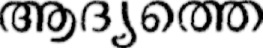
ആദ്യത്തെ
